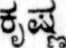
ಕೃಷ್ಣ
